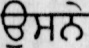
ਉਸਨੇ
